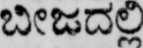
ಬೀಜದಲ್ಲಿ
